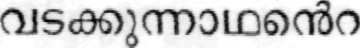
വടക്കുന്നാഥന്റെ
